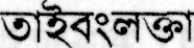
তাইবংলক্তা
